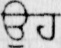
ਉਹ
